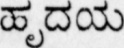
ಹೃದಯ
